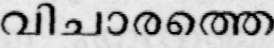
വിചാരത്തെ
